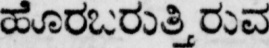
ಹೊರಬರುತ್ತಿರುವ
